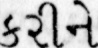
કરીને
